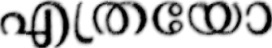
എത്രയോ
